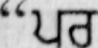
''ਪਰ
